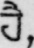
ਹੈ,
